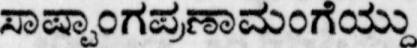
ಸಾಷ್ಟಾಂಗಪ್ರಣಾಮಂಗೆಯ್ದು
